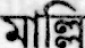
মাল্লি
